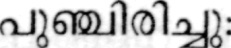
പുഞ്ചിരിച്ചു:
